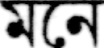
মনে
